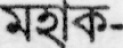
মহাক-
